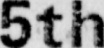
5th
